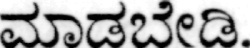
ಮಾಡಬೇಡಿ.
